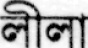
লীলা
